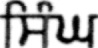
ਸਿੰਘ
